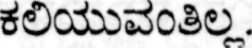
ಕಲಿಯುವಂತಿಲ್ಲ.
